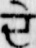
ਦੇ
